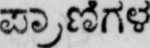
ಪ್ರಾಣಿಗಳ
